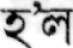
হ'ল
